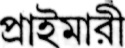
প্রাইমারী
